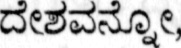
ದೇಶವನ್ನೋ,
